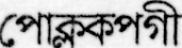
পোক্লকপগী
